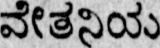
ವೇತನಿಯ
